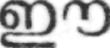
ഈ
